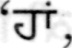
'ਹਾਂ,
